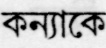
কন্যাকে
